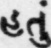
હતું
